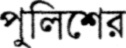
পুলিশের
